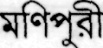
মণিপুরী
